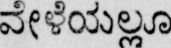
ವೇಳೆಯಲ್ಲೂ
